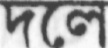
দলে
